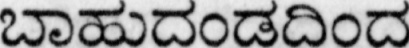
ಬಾಹುದಂಡದಿಂದ
